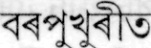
বৰপুখুৰীত
